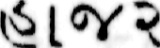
હાજર
